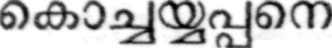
കൊച്ചയ്യപ്പനെ
